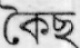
কৈছ
